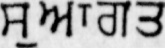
ਸੁਆਗਤ
